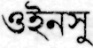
ওইনসু
